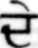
ਦੇ
